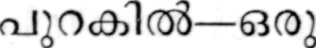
പുറകില്‍-ഒരു
